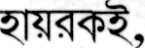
হায়রকই,
